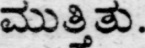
ಮುತ್ತಿತು.
